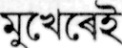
মুখেৰেই
